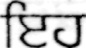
ਇਹ
